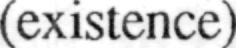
(existence)
